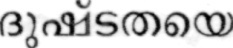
ദുഷ്ടതയെ
